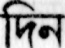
দিন
